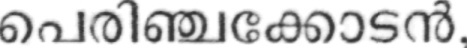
പെരിഞ്ചക്കോടന്‍,
